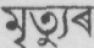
মৃত্যুৰ
